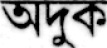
অদুক
